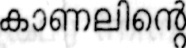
കാണലിന്റെ
